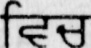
ਵਿਚ
